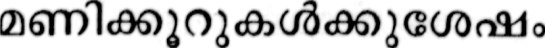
മണിക്കൂറുകള്‍ക്കുശേഷം
